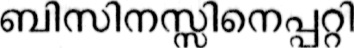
ബിസിനസ്സിനെപറ്റി
